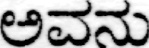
ಅವನು
